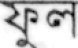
ফুল
